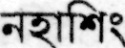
নহাশিং
